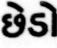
છેડો
